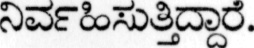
ನಿರ್ವಹಿಸುತ್ತಿದ್ದಾರೆ.
